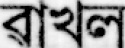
ৱাখল
